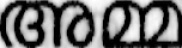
അമ്മ
